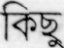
কিছু
